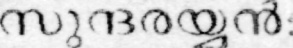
സുന്ദരയ്യന്‍:
